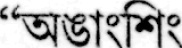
“অঙাংশিং
